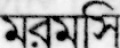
মরমসি
